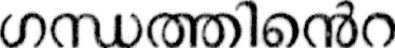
ഗന്ധത്തിന്റെ
